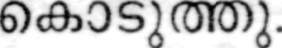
കൊടുത്തു.
